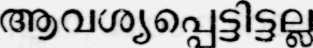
ആവശ്യപ്പെട്ടിട്ടല്ല
